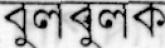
বুলবুলক
